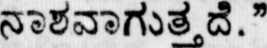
ನಾಶವಾಗುತ್ತದೆ.”
